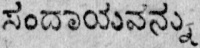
ಸಂದಾಯವನ್ನು
